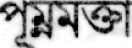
পূম্নমক্তা
